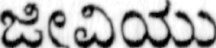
ಜೀವಿಯು
